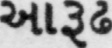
આરૂઢ
